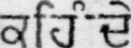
ਕਹਿੰਦੇ
